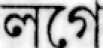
লগে
